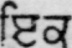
ਇਕ
